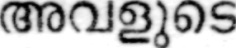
അവളുടെ
